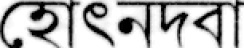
হোৎনদবা
